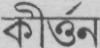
কীৰ্ত্তন
